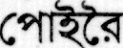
পোইরৈ
